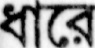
ধারে
